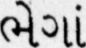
ભેગાં
